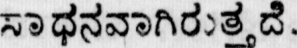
ಸಾಧನವಾಗಿರುತ್ತದೆ.
